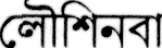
লৌশিনবা
